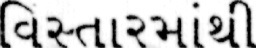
વિસ્તારમાંથી
